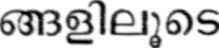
ങ്ങളിലൂടെ
